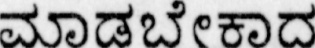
ಮಾಡಬೇಕಾದ
